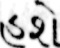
હશે
